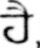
ਹੈ,
